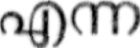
എന്ന
